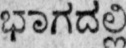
ಭಾಗದಲ್ಲಿ
